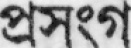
প্রসংগ
